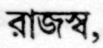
রাজস্ব,
